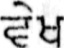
ਵੇਖ
